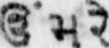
ઉંમરે
